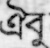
ঐবু
